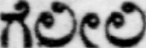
ಗೆಲೀಲಿ
